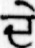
ਦੇ
